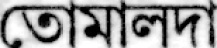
তোমালদা
